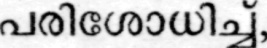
പരിശോധിച്ച്,
